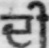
ਦੀ
